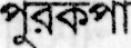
পুরকপা
